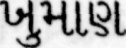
ખુમાણ
